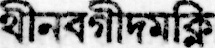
থীনবগীদমক্নি
